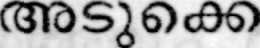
അടുക്കെ
